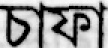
চাফা
